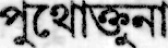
পুথোক্তুনা
